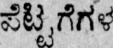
ಪೆಟ್ಟಿಗೆಗಳ
